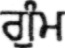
ਗੁੰਮ
